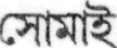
সোমাই
